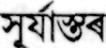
সূর্যাস্তৰ
